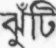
ঝুঁটি
